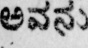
ಅವನು
